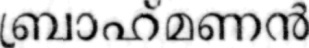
ബ്രാഹ്മണന്‍
